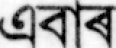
এবাৰ
